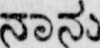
ನಾನು
